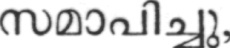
സമാപിച്ചു,
